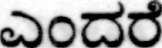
ಎಂದರೆ
